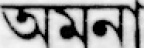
অমনা
